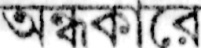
অন্ধকারে
